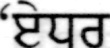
'ਏਧਰ
